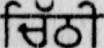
ਚਿੱਠੀ
